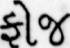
ફોજ
